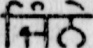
ਜਿੰਨੇ
